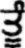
ਤੂੰ
